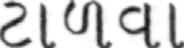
ટાળવા
